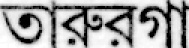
তারুরগা
